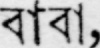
বাবা,
